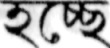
হচ্ছে
